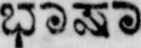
ಭಾಷಾ
